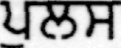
ਪੁਲਸ
